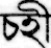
চহী
